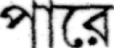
পারে
